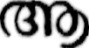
ആ
